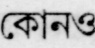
কোনও
